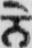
ਨੇ
